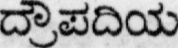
ದ್ರೌಪದಿಯ
